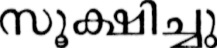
സൂക്ഷിച്ചു
